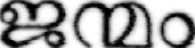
ജന്മം
